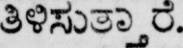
ತಿಳಿಸುತ್ತಾರೆ.
